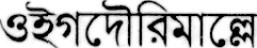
ওইগদৌরিমাল্লে
